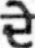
ਦੇ
